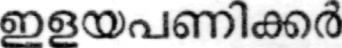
ഇളയപണിക്കര്‍
